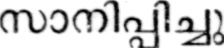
സാനിപ്പിച്ചു
